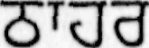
ਠਾਹਰ
